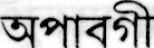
অপাবগী
